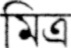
মিত্র
